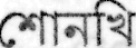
শোনখি
